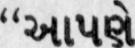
"આપણે
